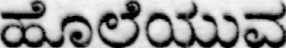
ಹೊಲೆಯುವ
